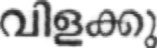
വിളക്കു
